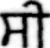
ਸੀ
